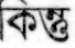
কিন্তু
